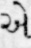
એ
